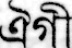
ঐগী
